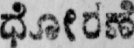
ಧೋರಣೆ
